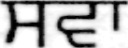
ਸਵਾ
